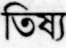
তিষ্য
